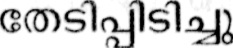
തേടിപ്പിടിച്ചു
